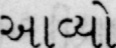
આવ્યો
